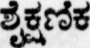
ಶೈಕ್ಷಣಿಕ
